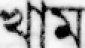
খাম
